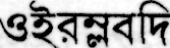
ওইরম্লবদি
